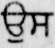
ਉਸ
